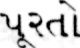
પૂરતો
